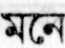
মনে
